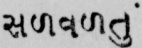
સળવળતું
